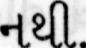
નથી.
